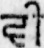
ਵੀ
